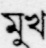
মুখ
